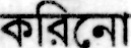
করিনো
